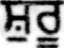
ਸ਼ੁਰੂ
